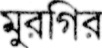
মুরগির
